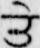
ਤੇ
